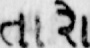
તારો
